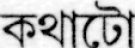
কথাটো
